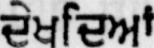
ਦੇਖਦਿਆਂ
